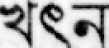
খৎন-চৈনরিবনি
